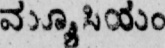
ಮ್ಯೂಸಿಯಂ
